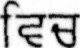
ਵਿਚ
